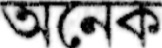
অনেক
